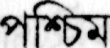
পশ্চিম
